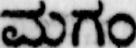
ಮಗಂ
